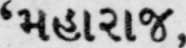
'મહારાજ,
